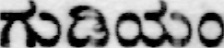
ಗುಡಿಯ೦
